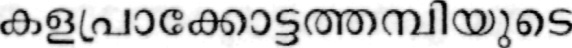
കളപ്രാക്കോട്ടത്തമ്പിയുടെ
